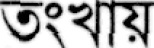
তংখায়
